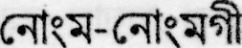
নোংম-নোংমগী
